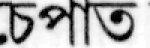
চেপাত
